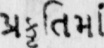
પ્રકૃતિમાં
